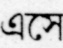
এসে
